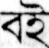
বই
